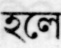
হলে
